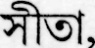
সীতা,
